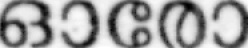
ഓരോ
